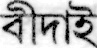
বীদাই
